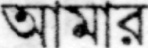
আমার
